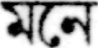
মনে
